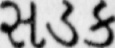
સડક
